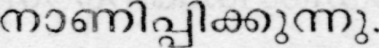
നാണിപ്പിക്കുന്നു.
